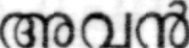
അവന്‍
